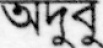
অদুবু
